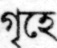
গৃহে
